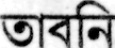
তাবনি
